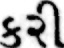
કરી
